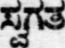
ಸ್ವಗತ
